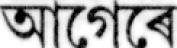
আগেৰে
